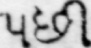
પછી
